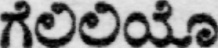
ಗೆಲಿಲಿಯೊ
